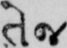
તેજ
